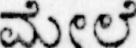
ಮೇಲೆ
